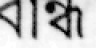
বান্ধ
